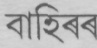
বাহিৰৰ
